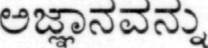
ಅಜ್ಞಾನವನ್ನು
